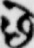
છે
